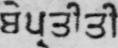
ਬੇਪ੍ਰਤੀਤੀ
